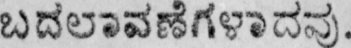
ಬದಲಾವಣೆಗಳಾದವು.
